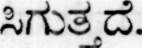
ಸಿಗುತ್ತದೆ.
